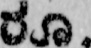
ರೂ,
